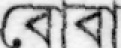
বোবা
